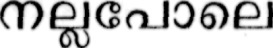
നല്ലപോലെ
